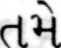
તમે
